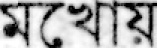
মখোয়
